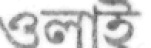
ওলাই
